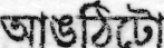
আঙঠিটো
